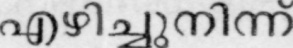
എഴിച്ചുനിന്ന്
